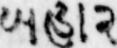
બહાર
